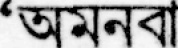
‘অমনবা
